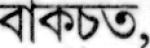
বাকচত,
